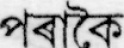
পৰাকৈ
